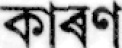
কাৰণ
